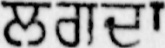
ਲਗਦਾ
